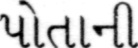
પોતાની
